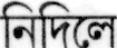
নিদিলে
